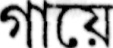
গায়ে
